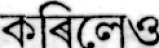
কৰিলেও
